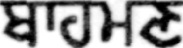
ਬਾਹਮਣ
